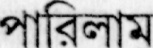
পারিলাম
